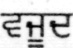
ਵਜੂਦ
